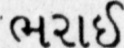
ભરાઈ
